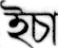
ইচা
